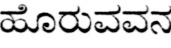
ಹೊರುವವನ
